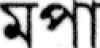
মপা
